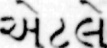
એટલે
